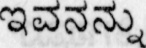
ಇವನನ್ನು
